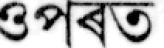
ওপৰত
